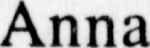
Anna
